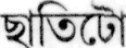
ছাতিটো
